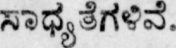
ಸಾಧ್ಯತೆಗಳಿವೆ.
